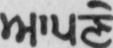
ਆਪਣੇ
